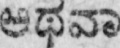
ಅಥವಾ
